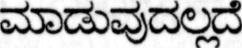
ಮಾಡುವುದಲ್ಲದೆ
